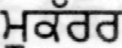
ਮੁਕੱਰਰ
